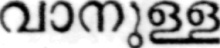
വാനുള്ള
